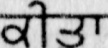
ਕੀਤਾ
